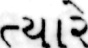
ત્યારે
